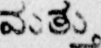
ಮತ್ತು
